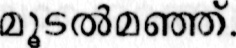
മൂടല്‍മഞ്ഞ്.
